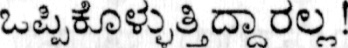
ಒಪ್ಪಿಕೊಳ್ಳುತ್ತಿದ್ದಾರಲ್ಲ!
